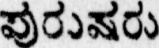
ಪುರುಷರು
